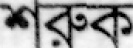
শরুক
